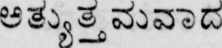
ಅತ್ಯುತ್ತಮವಾದ
